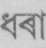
ধৰা
